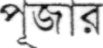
পূজার
